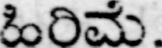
ಹಿರಿಮೆ.
